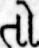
તો
